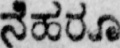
ನೆಹರೂ
